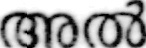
അല്‍
